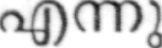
എന്നു
